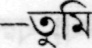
-তুমি
